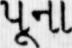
પૂના
